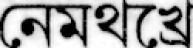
নেমথখ্রে
